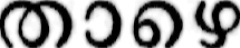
താഴെ
